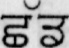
ਛੱਡ
